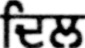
ਦਿਲ
